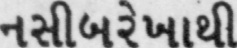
નસીબરેખાથી
